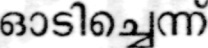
ഓടിച്ചെന്ന്
